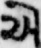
એ
